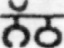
ਨੱਠ
